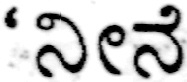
'ನೀನೆ
